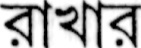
রাখার
